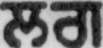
ਲਗ
